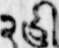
રહી
